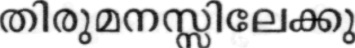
തിരുമനസ്സിലേക്കു
